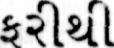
ફરીથી
